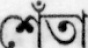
শেঁতা
